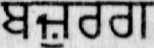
ਬਜ਼ੁਰਗ
